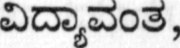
ವಿದ್ಯಾವಂತ,
